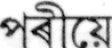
পৰীয়ে
